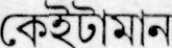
কেইটামান
